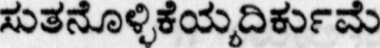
ಸುತನೊಳ್ಳಿಕೆಯ್ಯದಿರ್ಕುಮೆ
